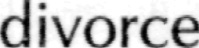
divorce
